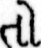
તો
